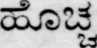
ಹೊಚ್ಚ
